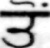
ਤੋਂ
